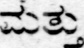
ಮತ್ತು
